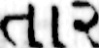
તાર
